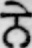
ਨੇ
